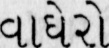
વાઘેરો
